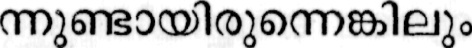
ന്നുണ്ടായിരുന്നെങ്കിലും
